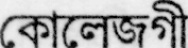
কোলেজগী
